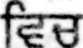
ਵਿਚ
